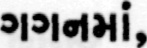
ગગનમાં,
